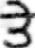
ਤੇ
